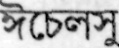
ঈচেলসু
